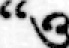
“ও
